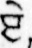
ਏ,
